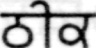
ਠੀਕ
